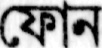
ফোন
